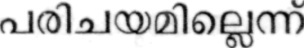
പരിചയമില്ലെന്ന്
